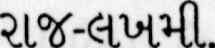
રાજ-લખમી.
